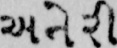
અનેરી
